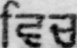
ਵਿਚ
